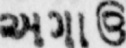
અગાઉ
